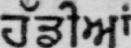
ਹੱਡੀਆਂ
